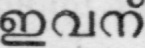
ഇവന്
